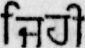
ਜਿਹੀ
